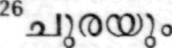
26ചുരയും
